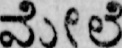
ಮೇಲೆ
